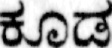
ಕೂಡ
